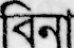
বিনা
